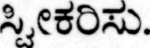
ಸ್ವೀಕರಿಸು.
